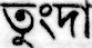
তুংদা
